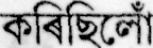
কৰিছিলোঁ
